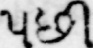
પછી
